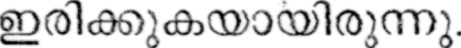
ഇരിക്കുകയായിരുന്നു.
